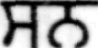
ਸਨ
